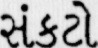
સંકટો
